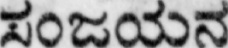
ಸಂಜಯನ
